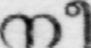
നീ
